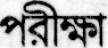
পরীক্ষা
